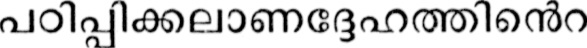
പഠിപ്പിക്കലാണദ്ദേഹത്തിന്റെ
